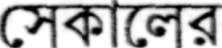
সেকালের
